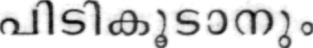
പിടികൂടാനും
